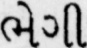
ભેગી
